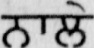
ਨਾਲੇ
